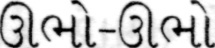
ઊભો-ઊભો
